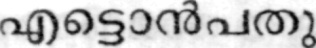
എട്ടൊന്‍പതു
